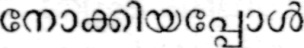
നോക്കിയപ്പോള്‍
